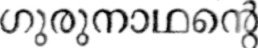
ഗുരുനാഥന്റെ
